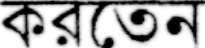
করতেন
